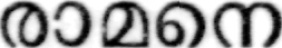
രാമനെ
